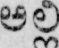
ಅಲ್ಲಿ
